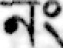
নং
